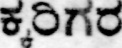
ಕ್ಕರಿಗರ
